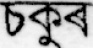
চকুৰ
